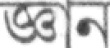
জ্ঞান
